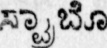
ಸ್ಟ್ರಾಬೊ
